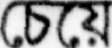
চেয়ে
